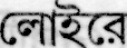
লোইরে
